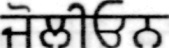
ਜੋਲੀਓਨ
